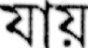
যায়
